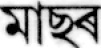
মাছৰ
